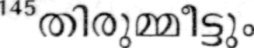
145തിരുമ്മീട്ടും
